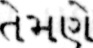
તેમણે
